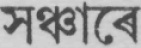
সঞ্চাৰে
